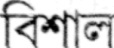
বিশাল
